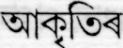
আকৃতিৰ
